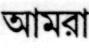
আমরা
